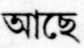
আছে
